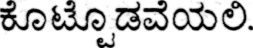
ಕೊಟ್ಟೊಡವೆಯಲಿ.
